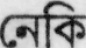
নেকি
